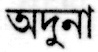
অদুনা
